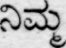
ನಿಮ್ಮ
